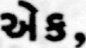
એક,
